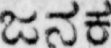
ಜನಕ
